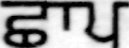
ਛਾਪ
